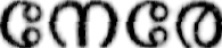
നേരേ
